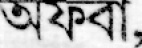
অফবা,
